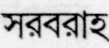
সরবরাহ
